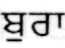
ਬੁਰਾ
